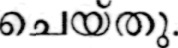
ചെയ്തു.
